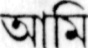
আমি
